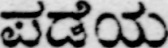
ಪಡೆಯ
